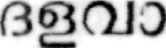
ദളവാ
